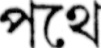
পথে
